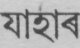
যাহাৰ
